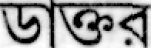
ডাক্তর
